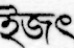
ইজৎ
